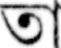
তা
